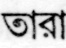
তারা
